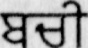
ਬਚੀ
